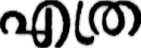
എത്ര
